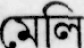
মেলি
